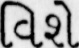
વિશે
